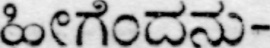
ಹೀಗೆಂದನು-
